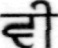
ਵੀ
